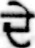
ਦੇ
